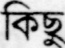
কিছু
